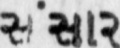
સંસાર
